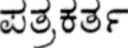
ಪತ್ರಕರ್ತ
